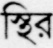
স্থির
